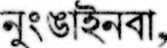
নুংঙাইনবা,
